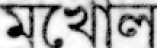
মখোল
